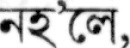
নহ'লে,
